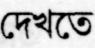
দেখতে
